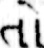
તો
